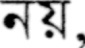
নয়,
